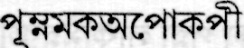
পূম্নমকঅপোকপী
